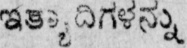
ಇತ್ಯಾದಿಗಳನ್ನು
